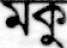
মকু
